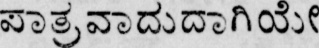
ಪಾತ್ರವಾದುದಾಗಿಯೇ
